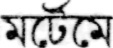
মর্টেমে
